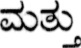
ಮತ್ತು
